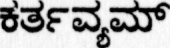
ಕರ್ತವ್ಯಮ್
